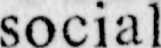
social
